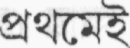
প্রথমেই
